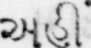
અહીં
